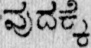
ವುದಕ್ಕೆ
